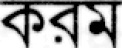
করম
